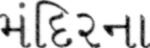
મંદિરના
